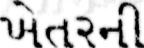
ખેતરની
